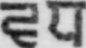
ਵਧ
